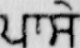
ਪਾਸੇ
